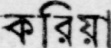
করিয়া
